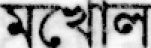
মখোল
